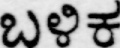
ಬಳಿಕ
